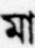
মা
